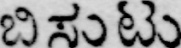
ಬಿಸುಟು
